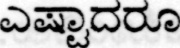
ಎಷ್ಟಾದರೂ
